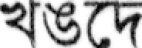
খঙদে
